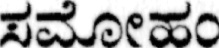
ಸಮೋಹಂ
